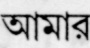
আমার
